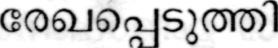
രേഖപ്പെടുത്തി
